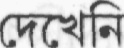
দেখেনি
